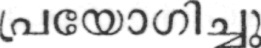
പ്രയോഗിച്ചു
